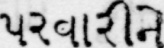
પરવારીને
